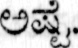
ಅಷ್ಟೆ.
